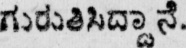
ಗುರುತಿಸಿದ್ದಾನೆ.
